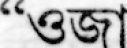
“ওজা
